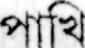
পাখি
